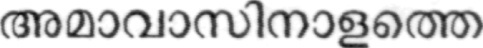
അമാവാസിനാളത്തെ
